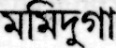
মমিদুগা
